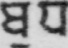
ਬੁਧ
